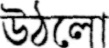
উঠলো
